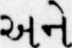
અને
